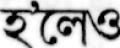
হ'লেও
